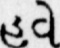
હવે
